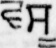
ਵਸੂ
